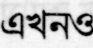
এখনও
